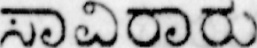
ಸಾವಿರಾರು
